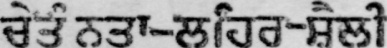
ਚੇਤੰਨਤਾ-ਲਹਿਰ-ਸ਼ੈਲੀ
